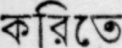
করিতে
